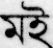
মই
